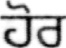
ਹੋਰ
